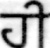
ਹੀ
